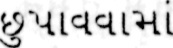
છુપાવવામાં
